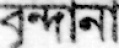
বৃন্দানা
